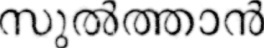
സുല്‍ത്താന്‍
